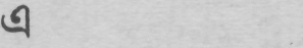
এ
